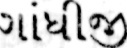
ગાંધીજી
